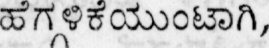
ಹೆಗ್ಗಳಿಕೆಯುಂಟಾಗಿ,
